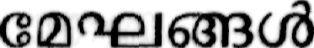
മേഘങ്ങള്‍
